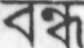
বন্ধ
